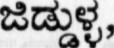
ಜಿಡ್ಡುಳ್ಳ,
